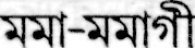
মমা-মমাগী
